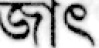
জাৎ
